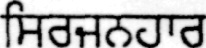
ਸਿਰਜਨਹਾਰ
